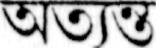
অত্যন্ত
